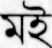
মই
